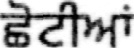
ਛੋਟੀਆਂ
